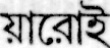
য়ারোই
